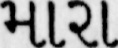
મારા
